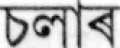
চলাৰ
